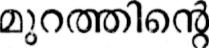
മുറത്തിന്റെ
